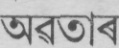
অৱতাৰ
